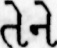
તેને
